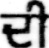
ਦੀ
